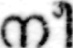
നീ
